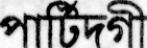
পার্টিদগী
